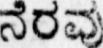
ನೆರವು
